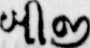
બીજી
